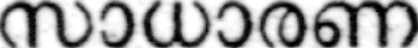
സാധാരണ
